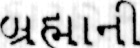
બ્રહ્માની
